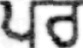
ਪਰ
